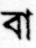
বা
